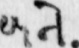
બને.
